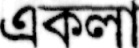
একলা
